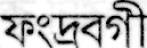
ফংদ্রবগী
